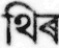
থিৰ
